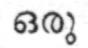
ഒരു
